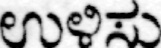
ಉಳಿಸು
